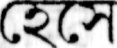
হেসে
